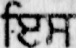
ਇਸ
